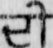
ਦੀ
